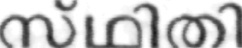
സ്ഥിതി
